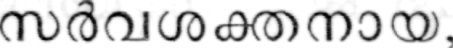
സര്‍വശക്തനായ,
